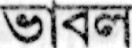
ভাবল
